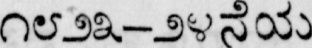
೧೮೨೩-೨೪ನೆಯ
